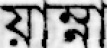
য়াম্না
